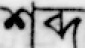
শব্দ
